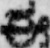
ಈ
